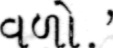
વળો.'
